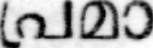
പ്രമാ
